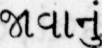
જાવાનું
